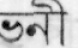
ভনী
